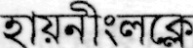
হায়নীংলক্লে
